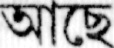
আছে
